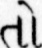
તો
